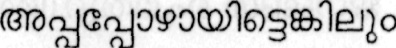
അപ്പപ്പോഴായിട്ടെങ്കിലും
